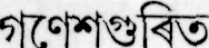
গণেশগুৰিত
